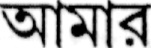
আমার
